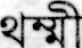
থম্মী
